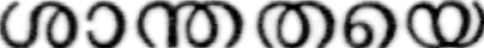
ശാന്തതയെ
